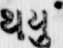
થયું
